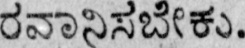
ರವಾನಿಸಬೇಕು.
